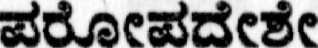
ಪರೋಪದೇಶೇ
